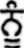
ਨੂੰ
